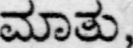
ಮಾತು,
